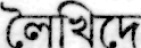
লৈখিদে
